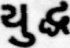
યુદ્ધ
